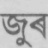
জুৰ
